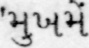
'મુખમેં
